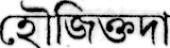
হৌজিক্তদা
